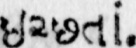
ઇચ્છતાં.
